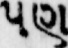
પણ
